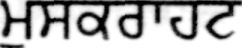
ਮੁਸਕਰਾਹਟ
